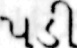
પડી
